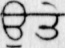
ਉਤੇ
